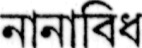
নানাবিধ
